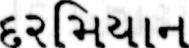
દરમિયાન
